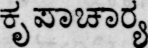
ಕೃಪಾಚಾರ್‍ಯ
